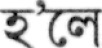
হ'লে
